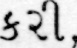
કરી,
